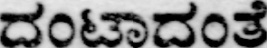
ದಂಟಾದಂತೆ
